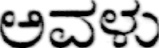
ಅವಳು
